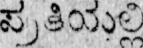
ಪ್ರತಿಯಲ್ಲಿ
